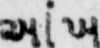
આંખ
